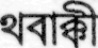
থবাক্কী
